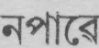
নপাৱে
